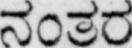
ನಂತರ
